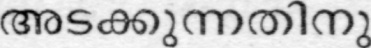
അടക്കുന്നതിനു
